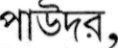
পাউদর,
